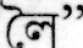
লৈ”
